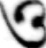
ও
